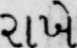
રાખે
